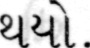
થયો.
